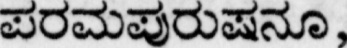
ಪರಮಪುರುಷನೂ,
